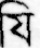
যি
